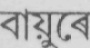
বায়ুৰে
